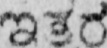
ಇತರ
